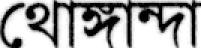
থোঙ্গন্দা
